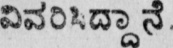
ವಿವರಿಸಿದ್ದಾನೆ.
